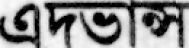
এদভান্স
